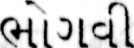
ભોગવી
